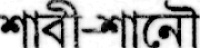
শাবী-শানৌ
